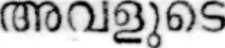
അവളുടെ
